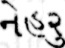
નેહરુ
